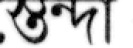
স্তেন্দা
